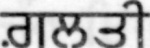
ਗ਼ਲਤੀ
